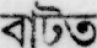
বাটত
